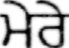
ਮੇਰੇ
